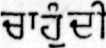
ਚਾਹੁੰਦੀ
